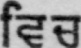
ਵਿਚ
